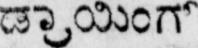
ಡ್ರಾಯಿಂಗ್
